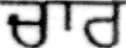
ਚਾਰ
